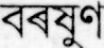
বৰষুণ
